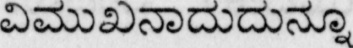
ವಿಮುಖನಾದುದುನ್ನೂ
